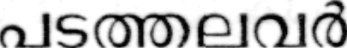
പടത്തലവര്‍
